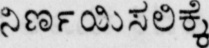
ನಿರ್ಣಯಿಸಲಿಕ್ಕೆ
